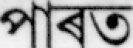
পাৰত
